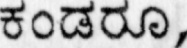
ಕಂಡರೂ,
